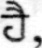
ਹੈ,
